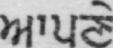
ਆਪਣੇ
